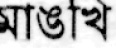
মাঙখি
